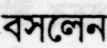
বসলেন
